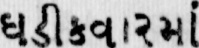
ઘડીકવારમાં
